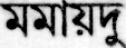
মমায়দু
